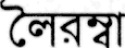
লৈরম্বা
